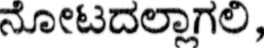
ನೋಟದಲ್ಲಾಗಲಿ,
